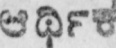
ಆರ್ಥಿಕ
